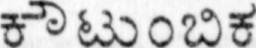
ಕೌಟುಂಬಿಕ
